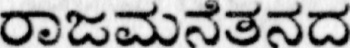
ರಾಜಮನೆತನದ
